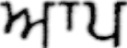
ਆਪ
